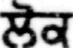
ਲੋਕ
